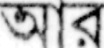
আর
